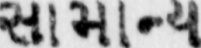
સામાન્ય
